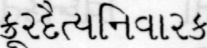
ક્રૂરદૈત્યનિવારક
